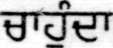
ਚਾਹੁੰਦਾ
